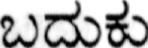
ಬದುಕು
